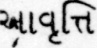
આવૃત્તિ
